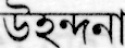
উহন্দনা
